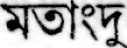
মতাংদু
